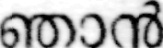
ഞാന്‍
